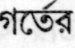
গর্তের
